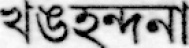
খঙহন্দনা
